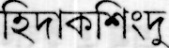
হিদাকশিংদু
